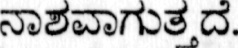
ನಾಶವಾಗುತ್ತದೆ.
